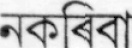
নকৰিবা
